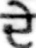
ਦੇ
